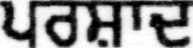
ਪਰਸ਼ਾਦ
